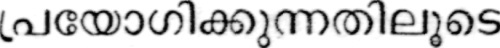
പ്രയോഗിക്കുന്നതിലൂടെ
